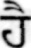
ਹੈ
